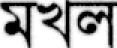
মখল
